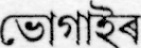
ভোগাইৰ
